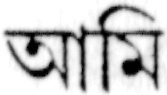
আমি
